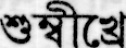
শুম্বীখ্রে
